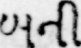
બની
